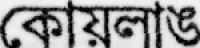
কোয়লাঙ
